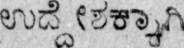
ಉದ್ದೇಶಕ್ಕಾಗಿ
